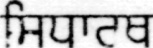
ਸਿਧਾਰਥ
